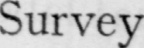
Survey
